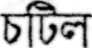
চটিল
